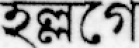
হল্লগে
